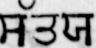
ਸੱਤਯ
